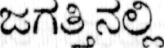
ಜಗತ್ತಿನಲ್ಲಿ
